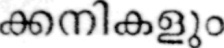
ക്കനികളും
